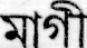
মাগী
